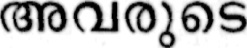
അവരുടെ
